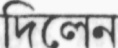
দিলেন
